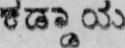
ಕಡ್ಡಾಯ
